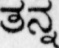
ತನ್ನ
